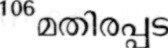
106മതിരപ്പട
